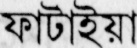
ফাটাইয়া
